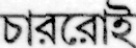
চাররোই
